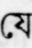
যে
